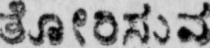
ತೋರಿಸುವ
